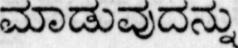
ಮಾಡುವುದನ್ನು
